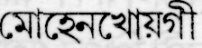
মোহেনখোয়গী
